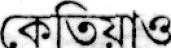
কেতিয়াও
